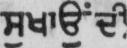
ਸੁਖਾਉਂਦੀ
